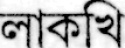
লাকখি
